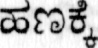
ಹಣಕ್ಕೆ
